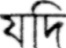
যদি
